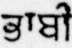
ਭਾਬੀ
